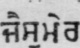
ਜੈਸੁਮੇਰ
